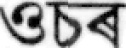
ওচৰ
